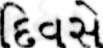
દિવસે
